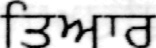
ਤਿਆਰ
